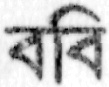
ববি
